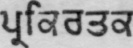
ਪ੍ਰਕਿਰਤਕ
